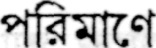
পরিমাণে
